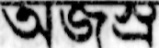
অজস্র
